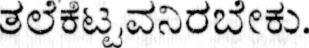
ತಲೆಕೆಟ್ಟವನಿರಬೇಕು.
